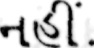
નહીં.
